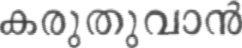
കരുതുവാന്‍
